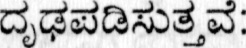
ದೃಢಪಡಿಸುತ್ತವೆ:
